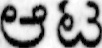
ಆಟ
